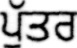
ਪੁੱਤਰ
